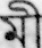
মী
